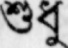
শুধু
